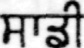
ਸਾਡੀ
